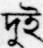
দুই
